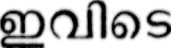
ഇവിടെ
